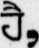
ਹੈ,
